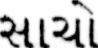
સાચો
